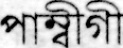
পাম্বীগী
